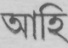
আহি
